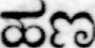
ಹಣ
